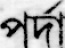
পর্দা
